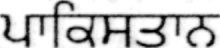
ਪਾਕਿਸਤਾਨ
